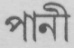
পানী
